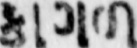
કાગળ
